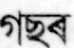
গছৰ
